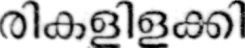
രികളിളക്കി
